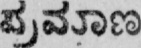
ಪ್ರಮಾಣ
